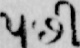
પછી
